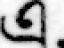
এ.
